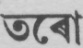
তৰো
